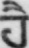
ਹੈ
